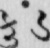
કુંડ
